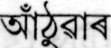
আঁঠুৱাৰ
